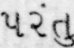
પરંતુ
